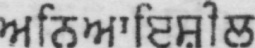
ਅਨਿਆਇਸ਼ੀਲ
